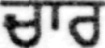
ਚਾਰ
